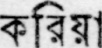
করিয়া
